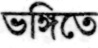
ভঙ্গিতে
